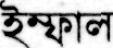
ইম্ফাল
